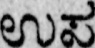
ಉಪ
